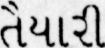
તૈયારી
